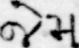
જેમ
